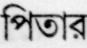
পিতার
